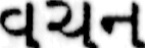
વચન
